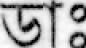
ডাঃ
